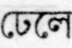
ঢেলে
